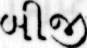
બીજી
